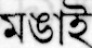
মঙাই
